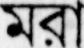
মরা
